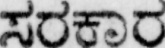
ಸರಕಾರ
